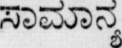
ಸಾಮಾನ್ಯ
